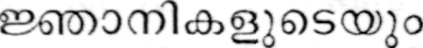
ജ്ഞാനികളുടെയും
